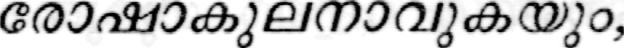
രോഷാകുലനാവുകയും,
